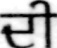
ਦੀ
